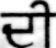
ਦੀ
